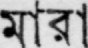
মারা
